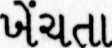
ખેંચતા
